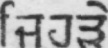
ਜਿਹੜੇ
